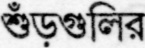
শুঁড়গুলির
